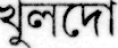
খুলদো
